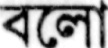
বলো
